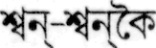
শ্বন্‌-শ্বন্‌কৈ
